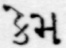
કેમ
